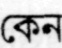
কেন
